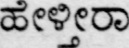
ಹೇಳ್ತೀರಾ
